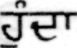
ਹੁੰਦਾ
